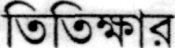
তিতিক্ষার
